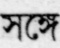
সঙ্গে
